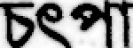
চৎপা
